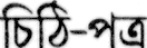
চিঠি-পত্র
